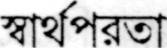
স্বার্থপরতা
